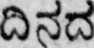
ದಿನದ
